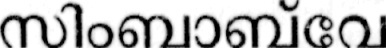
സിംബാബ്വേ
